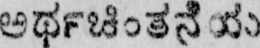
ಅರ್ಥಚಿಂತನೆಯ
